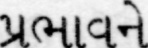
પ્રભાવને
